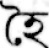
হৈ
